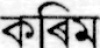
কৰিম
